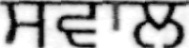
ਸਵਾਲ
